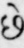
છે
